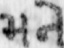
મને
